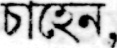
চাহেন,
